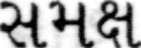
સમક્ષ
